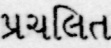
પ્રચલિત
